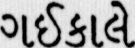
ગઈકાલે
